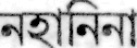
নহানিনা
